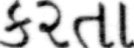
કરતા
